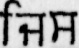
ਜਿਸ
